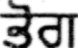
ਭੋਗ
